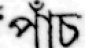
'পাঁচ
